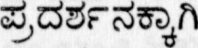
ಪ್ರದರ್ಶನಕ್ಕಾಗಿ
